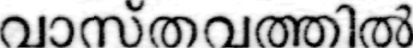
വാസ്തവത്തില്‍
